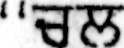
''ਚਲ
